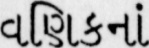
વણિકનાં
